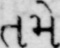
તમે
